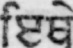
ਇਥੇ
